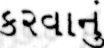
કરવાનું
